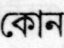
কোন
